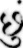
છું
